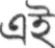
এই
